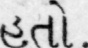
હતો.
